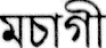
মচাগী
